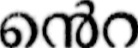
ന്റെ
